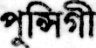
পুন্সিগী
